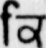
ਕਿ
